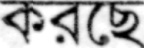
করছে
